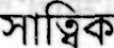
সাত্বিক
